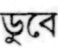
ডুবে
